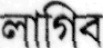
লাগিব
